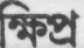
ক্ষিপ্র
